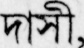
দাসী,
